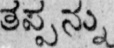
ತಪ್ಪನ್ನು
